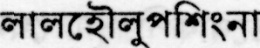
লালহৌলুপশিংনা
